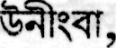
উনীংবা,
